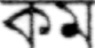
কম
